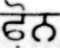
ਫ਼ੋਨ
